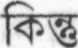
কিন্তু
